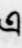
এ
